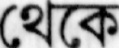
থেকে
